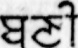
ਬਣੀ
